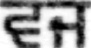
ਵਜ
